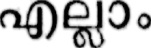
എല്ലാം
